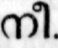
നീ.
